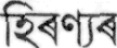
হিৰণ্যৰ
